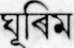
ঘূৰিম
